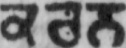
ਕਰਨ
